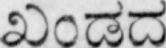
ಖಂಡದ
